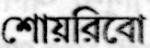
শোয়রিবো
